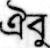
ঐবু
